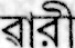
ৱারী
